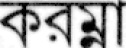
করম্না
